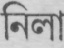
নিলা
